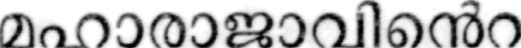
മഹാരാജാവിന്റെ
